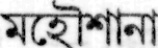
মহৌশানা
